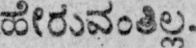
ಹೇರುವಂತಿಲ್ಲ.
